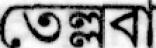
তেল্লবা
